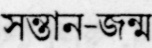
সন্তান-জন্ম
